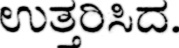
ಉತ್ತರಿಸಿದ.
